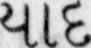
યાદ
